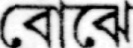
বোঝে
